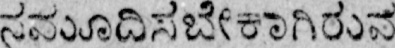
ನಮೂದಿಸಬೇಕಾಗಿರುವ
